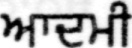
ਆਦਮੀ
